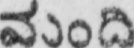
ಮಂದಿ
